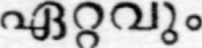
ഏറ്റവും
